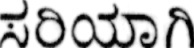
ಸರಿಯಾಗಿ
